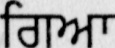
ਗਿਆ
